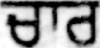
ਚਾਰ
